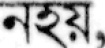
নহয়,
